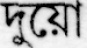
দুয়ো
